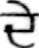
ਦੇ
